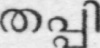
തപ്പി
